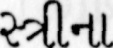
સ્ત્રીના
